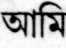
আমি
